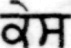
ਕੇਸ
